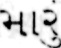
મારું
